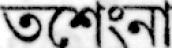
তশেংনা
